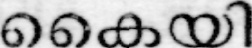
കൈയി
